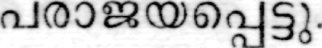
പരാജയപ്പെട്ടു.
